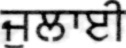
ਜੁਲਾਈ
